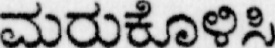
ಮರುಕೊಳಿಸಿ
